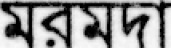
মরমদা
